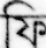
ফি
